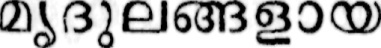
മൃദുലങ്ങളായ
